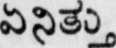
ಏನಿತ್ತು
